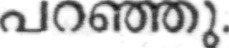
പറഞ്ഞു.
